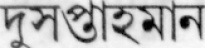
দুসপ্তাহমান
